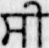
ਸੀ
